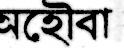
অহৌবা
